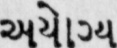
અયોગ્ય
